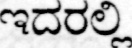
ಇದರಲ್ಲಿ
